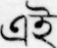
এই
